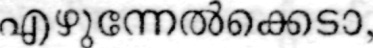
എഴുന്നേല്‍ക്കെടാ,
